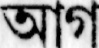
আগ
